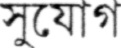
সুযোগ
